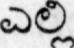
ಎಲ್ಲಿ
